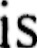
is
